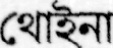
থোইনা
